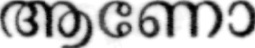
ആണോ
